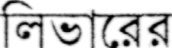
লিভারের
